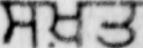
ਸਖ਼ਤ
